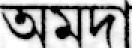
অমদা
